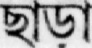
ছাড়া
